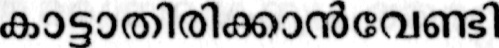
കാട്ടാതിരിക്കാന്‍വേണ്ടി
